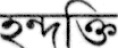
হন্দক্তি
